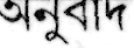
অনুবাদ
